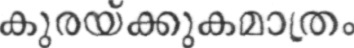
കുരയ്ക്കുകമാത്രം
